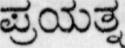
ಪ್ರಯತ್ನ
